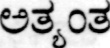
ಅತ್ಯಂತ
